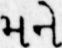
મને
